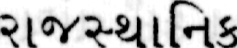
રાજસ્થાનિક
